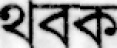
থবক
